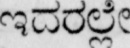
ಇದರಲ್ಲೇ
